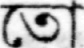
তো
